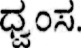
ಧ್ವಂಸ.
